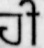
ਹੀ
